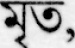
মৃত,
